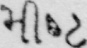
મીષ્ટ
